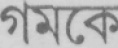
গমকে
